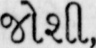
જોશી,
